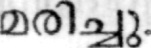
മരിച്ചു.
